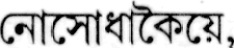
নোসোধাকৈয়ে,
